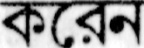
করেন
